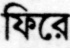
ফিরে
